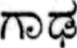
ಗಾಢ
